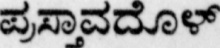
ಪ್ರಸ್ತಾವದೊಳ್
